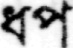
ধপ
